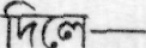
দিলে-
